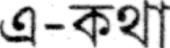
এ-কথা
